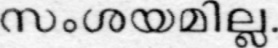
സംശയമില്ല.
